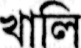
খালি
